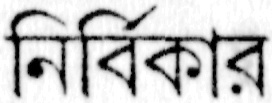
নির্বিকার
